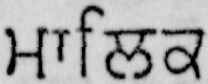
ਮਾਲਿਕ
